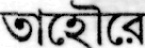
তাহৌরে
